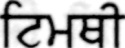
ਟਿਮਥੀ
